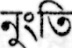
নুংতি
